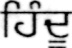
ਹਿੰਦੂ
